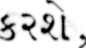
કરશે,
